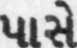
પાસે
